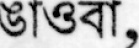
ঙাওবা,
